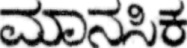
ಮಾನಸಿಕ
